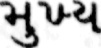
મુખ્ય
